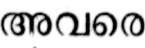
അവരെ
